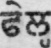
ਫੇਲ੍ਹ
